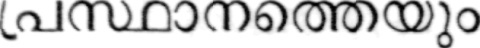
പ്രസ്ഥാനത്തെയും
